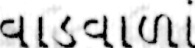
વાડવાળાં
